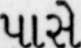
પાસે
